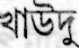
খাউদু
